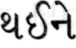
થઈને
